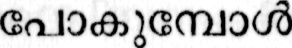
പോകുമ്പോള്‍
